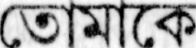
তোমাকে
